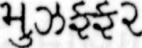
મુઝફ્ફર
